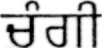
ਚੰਗੀ
